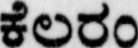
ಕೆಲರಂ
